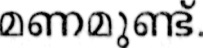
മണമുണ്ട്.
